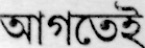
আগতেই
